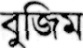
বুজিম
